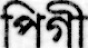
পিগী
